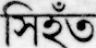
সিহঁত
